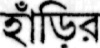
হাঁড়ির
